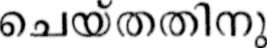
ചെയ്തതിനു
